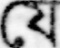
যে
